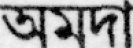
অমদা
